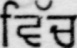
ਵਿੱਚ
